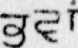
ਭਵਾਂ
